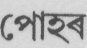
পোহৰ
